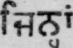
ਜਿਨ੍ਹਾਂ
